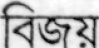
বিজয়
